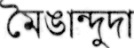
মৈঙান্দুদা
